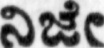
ನಿಜೇ
